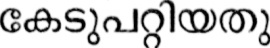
കേടുപറ്റിയതു
